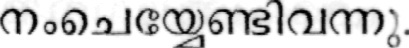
നംചെയ്യേണ്ടിവന്നു.
